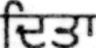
ਦਿਤਾ
